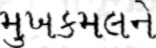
મુખકમલને
